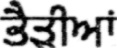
ਭੈੜੀਆਂ
